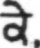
ਕੇ,
